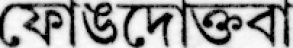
ফোঙদোক্তবা
